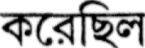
করেছিল
